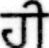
ਹੀ
